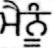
ਮੈਨੂੰ
